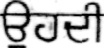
ਉਹਦੀ
